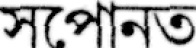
সপোনত
